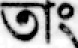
তাং
